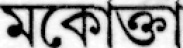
মকোক্তা
